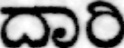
ದಾರಿ
